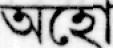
অহো
